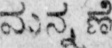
ಮನ್ನಣೆ
